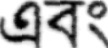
এবং
